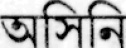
অসিনি
